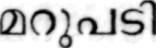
മറുപടി
